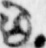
છે.
